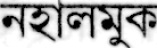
নহালমুক
